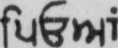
ਪਿਓਆਂ
